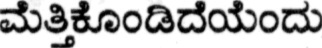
ಮೆತ್ತಿಕೊಂಡಿದೆಯೆಂದು
